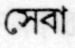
সেবা
